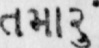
તમારું
